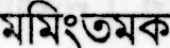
মমিংতমক
